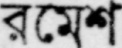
রমেশ
